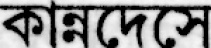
কান্নদেসে
